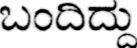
ಬಂದಿದ್ದು
